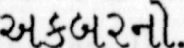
અકબરનો.
